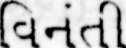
વિનંતી
